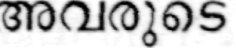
അവരുടെ
